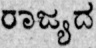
ರಾಜ್ಯದ
